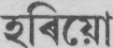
হৰিয়ো
